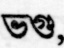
ভগু,
